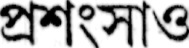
প্রশংসাও
